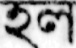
হল
